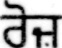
ਰੋਜ਼
